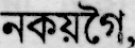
নকয়গৈ,
